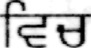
ਵਿਚ
